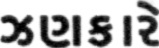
ઝણકારે
